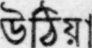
উঠিয়া
